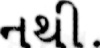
નથી.
